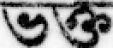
ভক্ত
